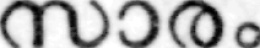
സാരം
